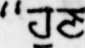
''ਹੁਣ
